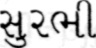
સુરભી
